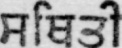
ਸਥਿਤੀ
